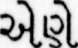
એણે
